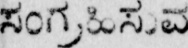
ಸಂಗ್ರಹಿಸುವ
